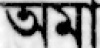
অমা
